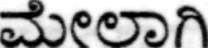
ಮೇಲಾಗಿ
